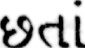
છતાં
